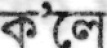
ক'লে
